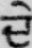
ਦੇ
